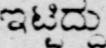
ಇಟ್ಟಿದ್ದು
